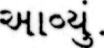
આવ્યું.
